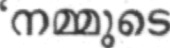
‘നമ്മുടെ
